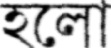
হলো
